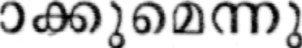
ാക്കുമെന്നു
